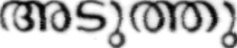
അടുത്തു
